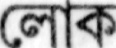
লোক
